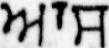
ਆਸ
